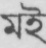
মই
